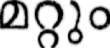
മറ്റും
